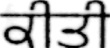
ਕੀਤੀ
